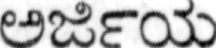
ಅರ್ಜಿಯ
